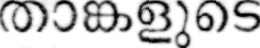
താങ്കളുടെ
